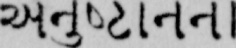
અનુષ્ટાનના
